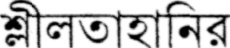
শ্লীলতাহানির
